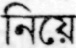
নিয়ে
